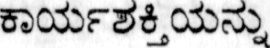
ಕಾರ್ಯಶಕ್ತಿಯನ್ನು
